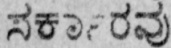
ಸರ್ಕಾರವು
